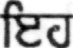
ਇਹ
